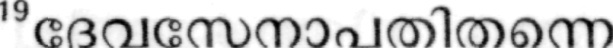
19ദേവസേനാപതിതന്നെ
